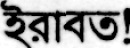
ইরাবত!
